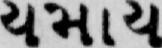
યમાય
